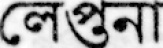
লেপ্তনা
